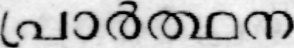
പ്രാര്‍ത്ഥന
